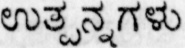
ಉತ್ಪನ್ನಗಳು
